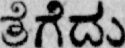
ತೆಗೆದು
